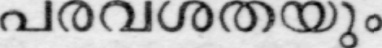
പരവശതയും
